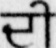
ਦੀ
